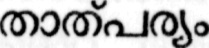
താത്പര്യം
